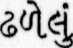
ઢળેલું
